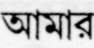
আমার
